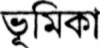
ভূমিকা
